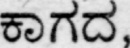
ಕಾಗದ,
